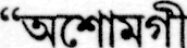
“অশোমগী
